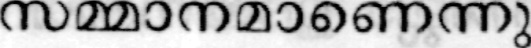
സമ്മാനമാണെന്നു
